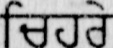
ਚਿਹਰੇ
